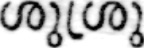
ശുശ്രു
